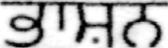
ਭਾਸ਼ਨ
